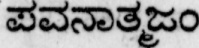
ಪವನಾತ್ಮಜಂ
